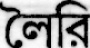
লৈরি
